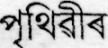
পৃথিৱীৰ
